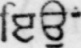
ਇਉਂ
